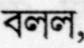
বলল,
